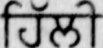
ਹਿੱਲੀ
